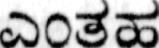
ಎಂತಹ
